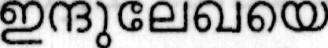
ഇന്ദുലേഖയെ
